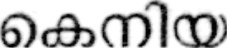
കെനിയ
